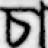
চা
